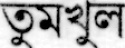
তুমখুল
